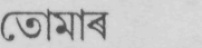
তোমাৰ
